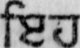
ਇਹ
